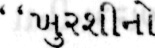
"ખુરશીનો
